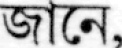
জানে,
